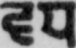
ਵਧ
